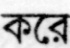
করে
